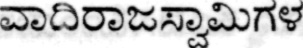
ವಾದಿರಾಜಸ್ವಾಮಿಗಳ
